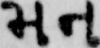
મન
